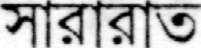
সারারাত
